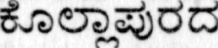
ಕೊಲ್ಲಾಪುರದ
